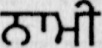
ਨਾਮੀ
